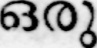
ഒരു
